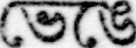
ভেঙে
